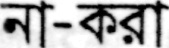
না-করা
